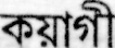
কয়াগী
